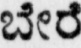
ಬೇರೆ
